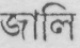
জালি
